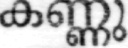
കണ്ണു
